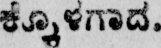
ಕ್ಕೊಳಗಾದ.
